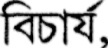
বিচার্য,
